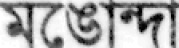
মঙোন্দা
